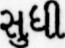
સુધી
